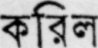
করিল
